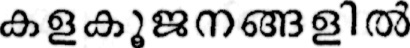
കളകൂജനങ്ങളില്‍
